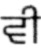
ਵੀ
